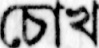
চোখ
